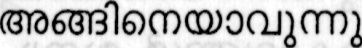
അങ്ങിനെയാവുന്നു
